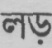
লড়
